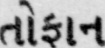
તોફાન
